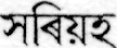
সৰিয়হ
